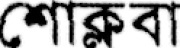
শোক্লবা
